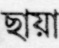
ছায়া
